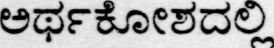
ಅರ್ಥಕೋಶದಲ್ಲಿ
